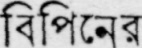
বিপিনের
